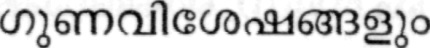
ഗുണവിശേഷങ്ങളും
